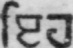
ਇਹ
